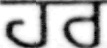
ਹਰ
